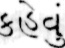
કહેવું
